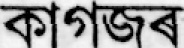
কাগজৰ
